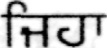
ਜਿਹਾ
